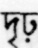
দৃঢ়
